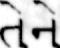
તેને
